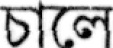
চালে
